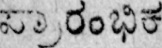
ಪ್ರಾರಂಭಿಕ
